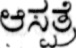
ಆಸ್ಪತ್ರೆ
